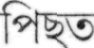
পিছত
